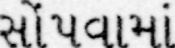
સોંપવામાં
